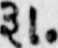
રૂ.
